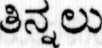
ತಿನ್ನಲು
